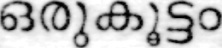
ഒരുകൂട്ടം
